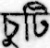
চুটি
